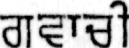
ਗਵਾਚੀ
